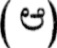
(ಆ)
